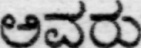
ಅವರು
